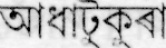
আধাটুকুৰা
